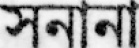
সনানা
